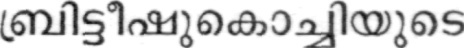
ബ്രിട്ടീഷുകൊച്ചിയുടെ
